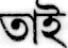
তাই
